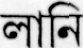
লানি
